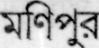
মণিপুর
